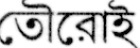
তৌরোই
